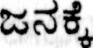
ಜನಕ್ಕೆ
